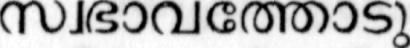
സ്വഭാവത്തോടു
